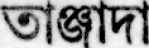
তাঞ্জাদা
